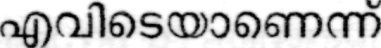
എവിടെയാണെന്ന്
